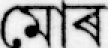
মোৰ
